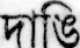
দাঙি
